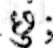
છું;
